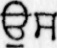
ਉਸ
